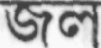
জল
